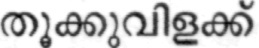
തൂക്കുവിളക്ക്
